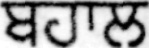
ਬਹਾਲ
